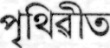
পৃথিৱীত
